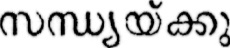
സന്ധ്യയ്ക്കു
